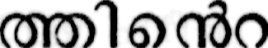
ത്തിന്റെ
